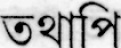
তথাপি
